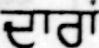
ਦਾਰਾਂ
